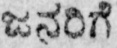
ಜನರಿಗೆ
